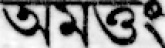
অমত্তং
